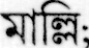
মাল্লি;
